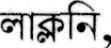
লাক্লনি,
